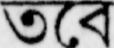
তবে
